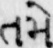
તમે
